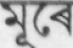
মূৰে
